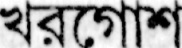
খরগোশ
